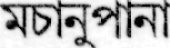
মচানুপানা
